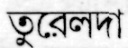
তুরেলদা
